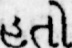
હતો
